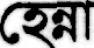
হেন্না
